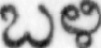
ಬಳಿ
